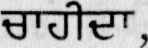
ਚਾਹੀਦਾ,
